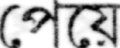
পেয়ে
